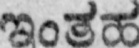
ಇಂತಹ
